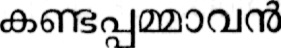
കണ്ടപ്പമ്മാവന്‍
